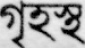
গৃহস্থ
